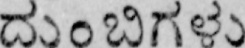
ದುಂಬಿಗಳು
